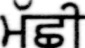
ਮੱਛੀ
